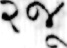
રજૂ
